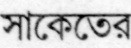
সাকেতের
